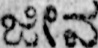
ಜೀವ
